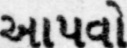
આપવો
